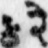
કરે
